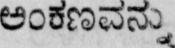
ಅಂಕಣವನ್ನು
